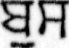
ਬੁਸ
